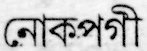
নোকপগী
